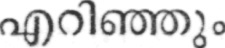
എറിഞ്ഞും
